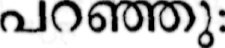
പറഞ്ഞു:
